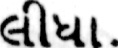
લીધા.
